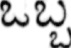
ಒಬ್ಬ
